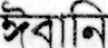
ঈবানি
